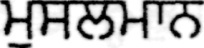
ਮੁਸਲਮਾਨ
